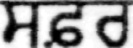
ਸਫ਼ਰ
